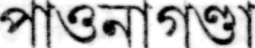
পাওনাগণ্ডা
